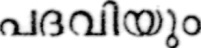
പദവിയും
